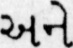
અને
